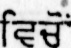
ਵਿਚੋਂ
